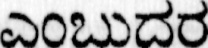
ಎಂಬುದರ
